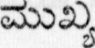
ಮುಖ್ಯ
